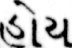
હોય
